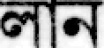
লান
